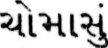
ચોમાસું
